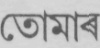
তোমাৰ
